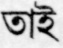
তাই
